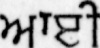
ਆਈ
